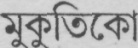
মুকুতিকো
